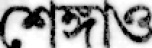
শেঙ্গাও
